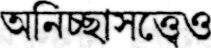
অনিচ্ছাসত্ত্বেও
